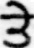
ਤੇ
